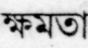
ক্ষমতা
